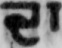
ਦਾ
